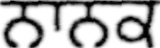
ਨਾਨਕ
